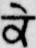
ਕੇ
